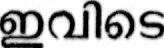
ഇവിടെ
